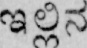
ಇಲ್ಲಿನ
